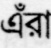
এঁরা
